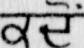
ਕਦੋਂ
